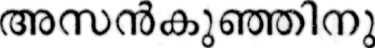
അസന്‍കുഞ്ഞിനു
